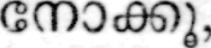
നോക്കൂ,
